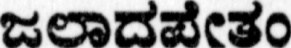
ಜಲಾದಪೇತಂ
